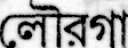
লৌরগা
